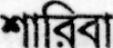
শারিবা
